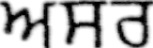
ਅਸਰ
